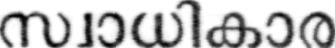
സ്വാധികാര
